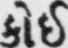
કોઈ
